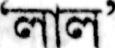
‘লাল’
